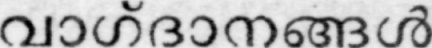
വാഗ്ദാനങ്ങള്‍
